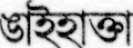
ঙাইহাক্তা
